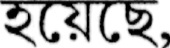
হয়েছে,
